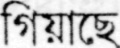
গিয়াছে
